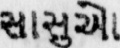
સાસુઓ
